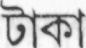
টাকা
